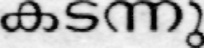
കടന്നു
